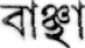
বাঞ্ছা
